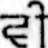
ਵੀ
